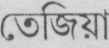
তেজিয়া
